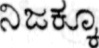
ನಿಜಕ್ಕೂ
